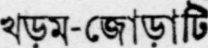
খড়ম-জোড়াটি
